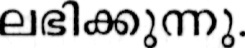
ലഭിക്കുന്നു.
